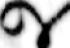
જ
